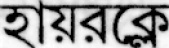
হায়রক্লে
